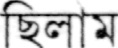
ছিলাম
